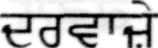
ਦਰਵਾਜ਼ੇ
